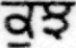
ਕੁਝ
